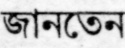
জানতেন
